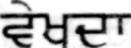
ਵੇਖਦਾ
